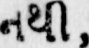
નથી,
